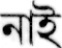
নাই
